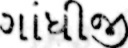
ગાંધીજી
